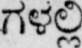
ಗಳಲ್ಲಿ
